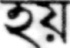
হয়
